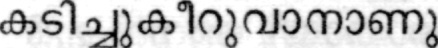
കടിച്ചുകീറുവാനാണു
